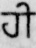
ਹੀ
